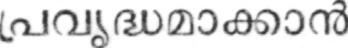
പ്രവൃദ്ധമാക്കാന്‍
